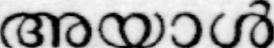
അയാള്‍
